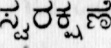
ಸ್ವರಕ್ಷಣೆ
